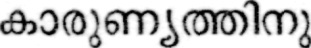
കാരുണ്യത്തിനു
